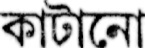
কাটানো
